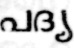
പദ്യ
